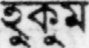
হুকুম
